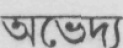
অভেদ্য
